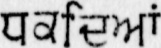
ਧਕਦਿਆਂ
